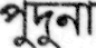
পুদুনা
